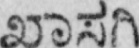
ಖಾಸಗಿ
